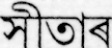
সীতাৰ
